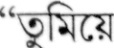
"তুমিয়ে
